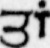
ਤਾਂ
